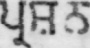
ਪ੍ਰਸ਼ਨ
